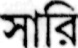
সারি
